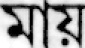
মায়
